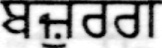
ਬਜ਼ੁਰਗ
